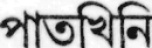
পাতখিনি
